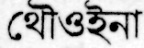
থৌওইনা
